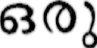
ഒരു
